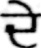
ਦੇ
